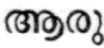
ആരു
